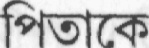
পিতাকে
